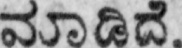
ಮಾಡಿದೆ.
